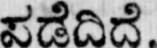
ಪಡೆದಿದೆ.
